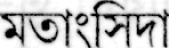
মতাংসিদা
